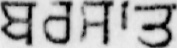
ਬਰਸਾਤ
